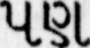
પણ
